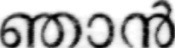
ഞാന്‍
